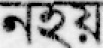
নহয়
